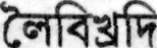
লৈবিখ্রদি
